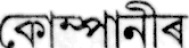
কোম্পানীৰ
